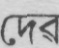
দেৱ
